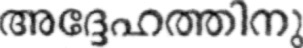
അദ്ദേഹത്തിനു
